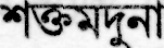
শক্তমদুনা
